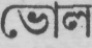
ভোল
